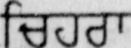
ਚਿਹਰਾ
